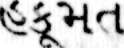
હકૂમત
